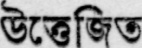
উত্তেজিত
